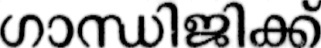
ഗാന്ധിജിക്ക്
